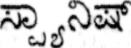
ಸ್ಪ್ಯಾನಿಷ್
